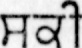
ਸਕੀ
